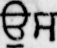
ਉਸ
